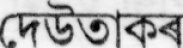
দেউতাকৰ
